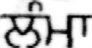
ਲੰਮਾ
